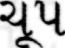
ચૂપ
